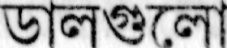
ডালগুলো
